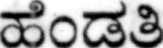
ಹೆಂಡತಿ
